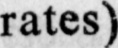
rates)
